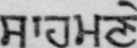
ਸਾਹਮਣੇ
